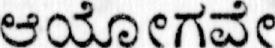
ಆಯೋಗವೇ
